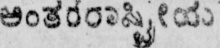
ಅಂತರರಾಷ್ಟ್ರೀಯ
